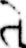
તે
